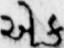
એક
